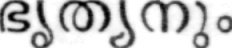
ഭൃത്യനും
